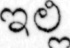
ಇಲ್ಲಿ
